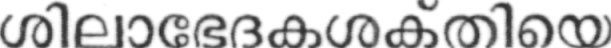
ശിലാഭേദകശക്തിയെ
